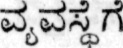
ವ್ಯವಸ್ಥೆಗೆ
